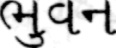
ભુવન
